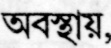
অবস্থায়,
